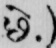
છે.)
